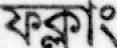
ফক্লাং
